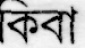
কিবা
